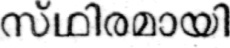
സ്ഥിരമായി
